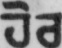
ਹੋਰ
